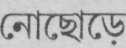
নোছোড়ে
